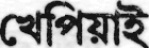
খেপিয়াই
